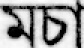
মচা
